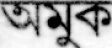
অমুক
